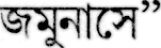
জমুনাসে”
